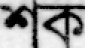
শক
